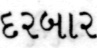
દરબાર
